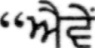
''ਐਵੇਂ
